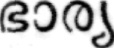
ഭാര്യ
